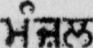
ਮੰਜ਼ਲ
